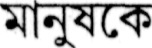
মানুষকে
